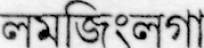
লমজিংলগা
